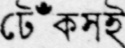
টেঁকসই
